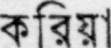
করিয়া
